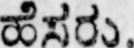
ಹೆಸರು.
